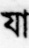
যা
